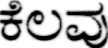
ಕೆಲವು
